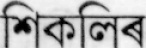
শিকলিৰ
